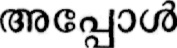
അപ്പോള്‍
